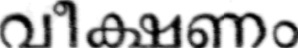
വീക്ഷണം
